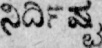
ನಿರ್ದಿಷ್ಟ
